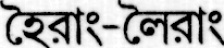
হৈরাং-লৈরাং
